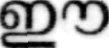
ഈ
